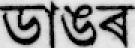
ডাঙৰ
